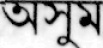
অসুম
